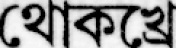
থোকখ্রে
